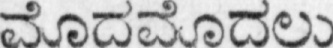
ಮೊದಮೊದಲು
